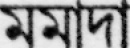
মমাদা
